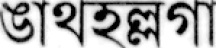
ঙাথহল্লগা
